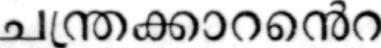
ചന്ത്രക്കാറന്റെ
